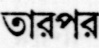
তারপর
